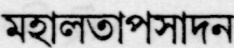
মহালতাপসাদন
